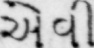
એવી
